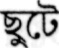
ছুটে
